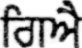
ਗਿਐ
